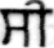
ਸੀ
